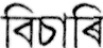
বিচাৰি
